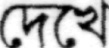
দেখে
